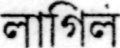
লাগিল
